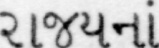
રાજ્યનાં
